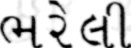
ભરેલી
